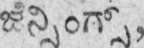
ಜೆನ್ಸಿಂಗ್ಸ್,
